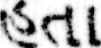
હતા
